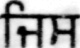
ਜਿਸ
